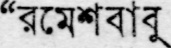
‘‘রমেশবাবু
